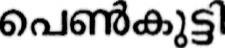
പെണ്‍കുട്ടി
